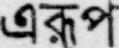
এরূপ
